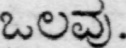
ಒಲವು.
